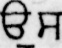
ਉਸ
